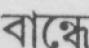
বান্ধে
